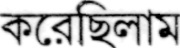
করেছিলাম
